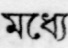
মধ্যে
